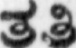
ತತಿ
